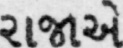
રાજાએ
